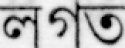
লগত
